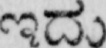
ಇದು
